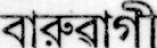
বারুৱাগী
